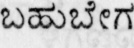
ಬಹುಬೇಗ
